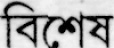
বিশেষ
